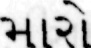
મારો
